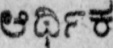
ಆರ್ಥಿಕ
